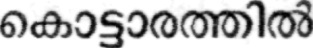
കൊട്ടാരത്തില്‍
